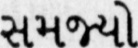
સમજ્યો
